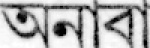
অনাবা
